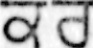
ਕਰ
